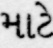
માટે
